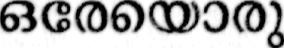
ഒരേയൊരു
